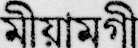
মীয়ামগী
